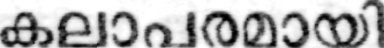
കലാപരമായി
